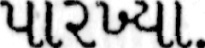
પારખ્યા.
